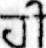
ਹੀ
